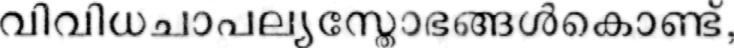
വിവിധചാപല്യസ്തോഭങ്ങള്‍കൊണ്ട്,
